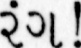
રંગ!
